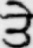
ਤੇ
